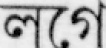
লগে
